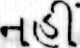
નહીં
